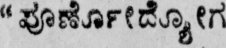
“ಪೂರ್ಣೋದ್ಯೋಗ
